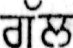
ਗੱਲ
